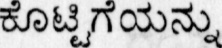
ಕೊಟ್ಟಿಗೆಯನ್ನು
